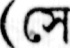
(সে
